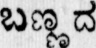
ಬಣ್ಣದ
